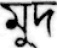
মুদ
